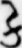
કે
